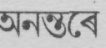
অনন্তৰে
